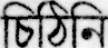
চিঠিনি
